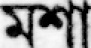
মশা
